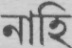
নাহি
